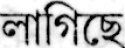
লাগিছে
